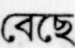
বেছে
